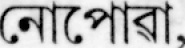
নোপোৱা,
